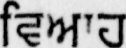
ਵਿਆਹ
